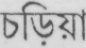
চড়িয়া
